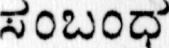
ಸಂಬಂಧ
